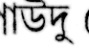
পাউদু
